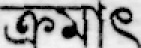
ক্রমাৎ
